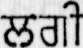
ਲਗੀ
